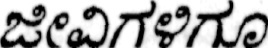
ಜೀವಿಗಳಿಗೂ
